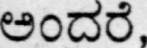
ಅಂದರೆ,
